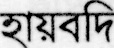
হায়বদি
